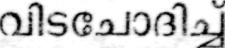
വിടചോദിച്ച്
